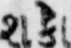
શકો
